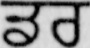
ਡਰ
